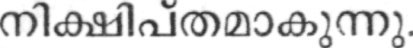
നിക്ഷിപ്തമാകുന്നു.
